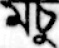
মচু
